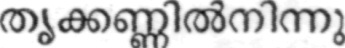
തൃക്കണ്ണില്‍നിന്നു
